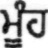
ਮੂੰਹ
